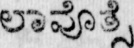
ಲಾವೊತ್ಸೆ
